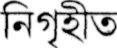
নিগৃহীত
